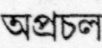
অপ্রচল
